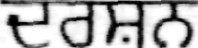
ਦਰਸ਼ਨ
